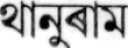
থানুৰাম
